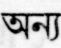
অন্য
